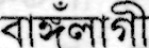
বাঙ্গঁলাগী
